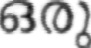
ഒരു
